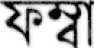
ফম্বা
